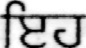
ਇਹ
